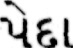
પેદા
